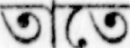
তাতে
